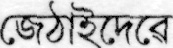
জেঠাইদেৱে
